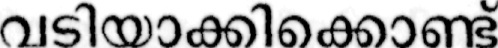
വടിയാക്കിക്കൊണ്ട്
